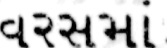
વરસમાં
